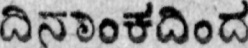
ದಿನಾಂಕದಿಂದ
